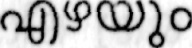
എഴയും
